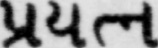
પ્રયત્ન
